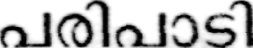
പരിപാടി
